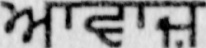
ਆਵਾਜ਼
